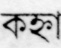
কহ্না
